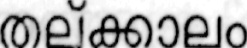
തല്ക്കാലം
